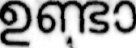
ഉണ്ടാ
